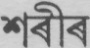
শৰীৰ
